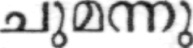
ചുമന്നു
